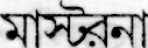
মস্টরনা
